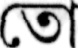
তো
